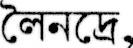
লৈনদ্রে,
